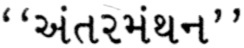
“અંતરમંથન"
